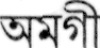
অমগী
